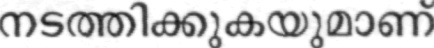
നടത്തിക്കുകയുമാണ്
